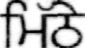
ਮਿੱਠੇ
